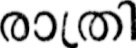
രാത്രി
